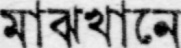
মাঝখানে
